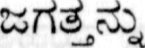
ಜಗತ್ತನ್ನು
